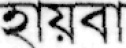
হায়বা
